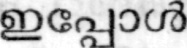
ഇപ്പോള്‍
